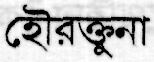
হৌরক্তুনা
